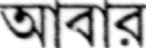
আবার
